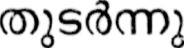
തുടര്‍ന്നു
